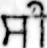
ਸੀ
